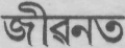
জীৱনত
